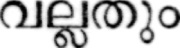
വല്ലതും
